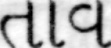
તાવ
